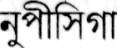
নুপীসিগা
